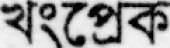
খংপ্রেক
